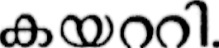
കയററി.
